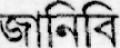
জানিবি
